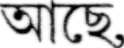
আছে,
